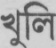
খুলি
